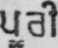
ਪੂਰੀ
